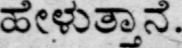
ಹೇಳುತ್ತಾನೆ.
